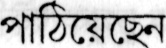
পাঠিয়েছেন
